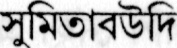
সুমিতাবউদি
